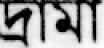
দ্রামা
